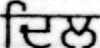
ਦਿਲ
